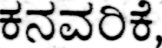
ಕನವರಿಕೆ,
